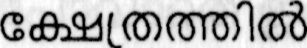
ക്ഷേത്രത്തില്‍
